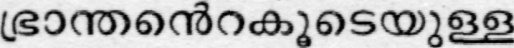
ഭ്രാന്തന്റെകൂടെയുള്ള
